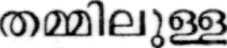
തമ്മിലുള്ള
